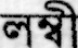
লম্বী
